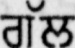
ਗੱਲ
